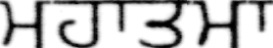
ਮਹਾਤਮਾ
